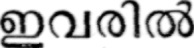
ഇവരില്‍
